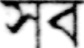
সব
